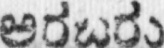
ಅರಬರು
